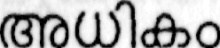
അധികം
